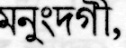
মনুংদগী,
